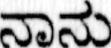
ನಾನು
